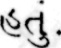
હતું.
